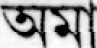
অমা
